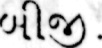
બીજી.
